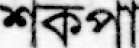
শকপা
